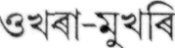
ওখৰা-মুখৰি
